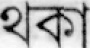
থকা
